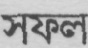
সফল
